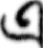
এ
